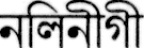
নলিনীগী
